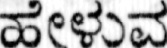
ಹೇಳುವ
